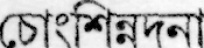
চোংশিন্নদনা
